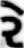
રે
